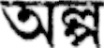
অল্প
